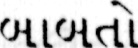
બાબતો
